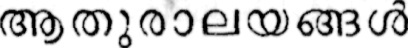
ആതുരാലയങ്ങള്‍
